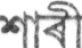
শাৰী
